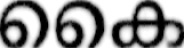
കൈ
